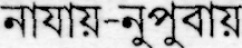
নাযায়-নুপুবায়
